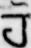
ਹੋ
